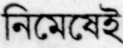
নিমেষেই
